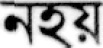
নহয়
